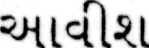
આવીશ
